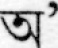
অ'
